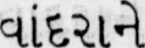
વાંદરાને
